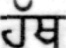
ਹੱਥ
